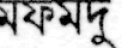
মফমদু
